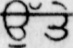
ਉੱਤੇ
